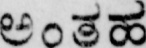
ಅಂತಹ
